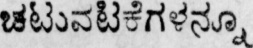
ಚಟುವಟಿಕೆಗಳನ್ನೂ
